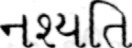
નશ્યતિ
